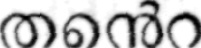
തന്റെ
